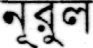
নূরুল
